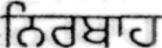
ਨਿਰਬਾਹ
